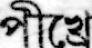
পীখ্রে
